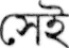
সেই
